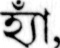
হ্যাঁ,
